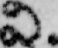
ವಿ.
